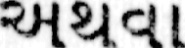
અથવા
